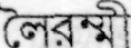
লৈরম্মী
